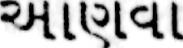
આણવા
